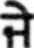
ਜੇ
